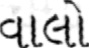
વાલો
